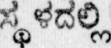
ಸ್ಥಳದಲ್ಲಿ
